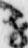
કે
